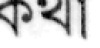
কথা
